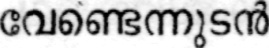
വേണ്ടെന്നുടന്‍
